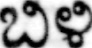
ಬಿಳಿ
